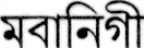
মবানিগী
